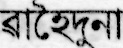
ৱাহৈদুনা
